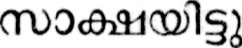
സാക്ഷയിട്ടു
